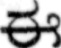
ಈ
